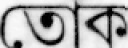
তোক
